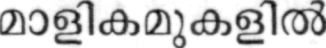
മാളികമുകളില്‍
